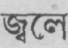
জ্বলে
